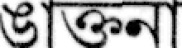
ঙাক্তনা
